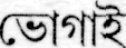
ভোগাই
